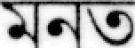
মনত
